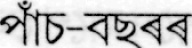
পাঁচ-বছৰৰ
